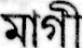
মাগী
